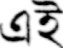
এই
